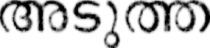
അടുത്ത
